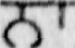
ਨਾ
